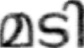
മടി
